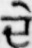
ਦੇ
